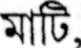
মাটি,
